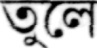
তুলে
